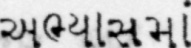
અભ્યાસમાં
